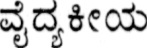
ವೈದ್ಯಕೀಯ
